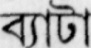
ব্যাটা
